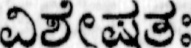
ವಿಶೇಷತಃ
